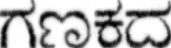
ಗಣಕದ
